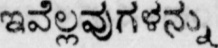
ಇವೆಲ್ಲವುಗಳನ್ನು
